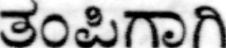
ತಂಪಿಗಾಗಿ
